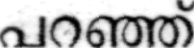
പറഞ്ഞ്
